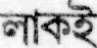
লাকই
